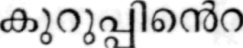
കുറുപ്പിന്റെ
